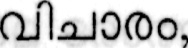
വിചാരം,
